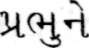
પ્રભુને
